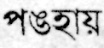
পঙহায়
